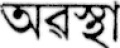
অৱস্থা
